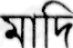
মাদি
